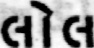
લોલ
